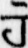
ਹੋ
